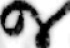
જ
